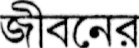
জীবনের
